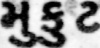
મુકુટ
